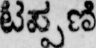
ಟಿಪ್ಪಣಿ
